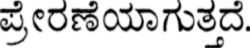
ಪ್ರೇರಣೆಯಾಗುತ್ತದೆ.
